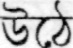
উঠে
